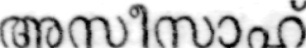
അസീസാഹ്
